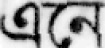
এনে
